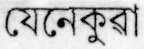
যেনেকুৱা
